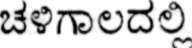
ಚಳಿಗಾಲದಲ್ಲಿ
